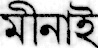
মীনাই
